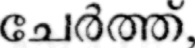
ചേര്‍ത്ത്,
